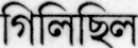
গিলিছিল
